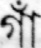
গাঁ
